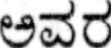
ಅವರ
